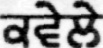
ਕਵੇਲੇ
